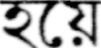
হয়ে
